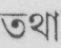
তথা
